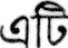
এটি
